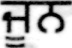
ਜੂਨ
